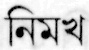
নিমখ
